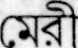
মেরী
